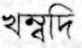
খম্বদি
